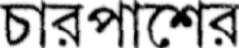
চারপাশের
